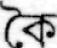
কৈ
